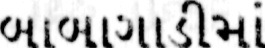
બાબાગાડીમાં
